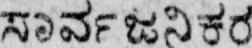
ಸಾರ್ವಜನಿಕರ
